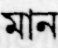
মান
